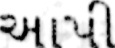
આપી
